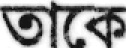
তাকে
